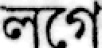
লগে
